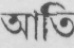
আতি
